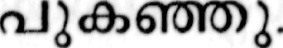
പുകഞ്ഞു.
